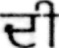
ਦੀ
